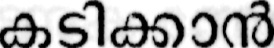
കടിക്കാന്‍
